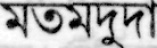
মতমদুদা
